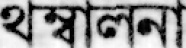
থম্বালনা
